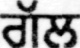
ਗੱਲ
